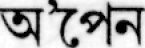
অ'পেন
